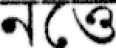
নত্তে
